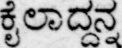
ಕೈಲಾದ್ದನ್ನ
